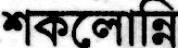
শকলোন্নি
